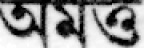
অমত্তা
